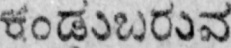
ಕಂಡುಬರುವ
